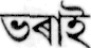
ভৰাই
